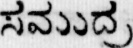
ಸಮುದ್ರ
